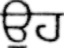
ਉਹ
